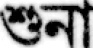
শুনা
